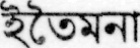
ইতৈমনা
